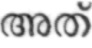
അത്
